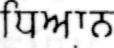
ਧਿਆਨ
